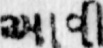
આવી
